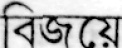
বিজয়ে
